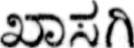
ಖಾಸಗಿ
